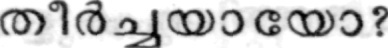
തീര്‍ച്ചയായോ?
